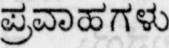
ಪ್ರವಾಹಗಳು
